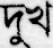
দুখ
